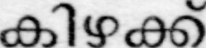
കിഴക്ക്
